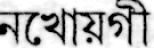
নখোয়গী
